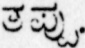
ತಪ್ಪು.
